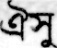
ঐসু
